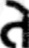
તે
